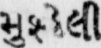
મુશ્કેલી
